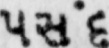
પસંદ
